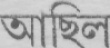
আছিল
